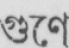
গুণে
